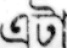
এটা
